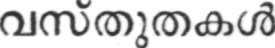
വസ്തുതകള്‍
